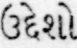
ઉદેશો
